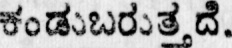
ಕಂಡುಬರುತ್ತದೆ.
